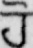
ਹੋ
